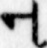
ન
